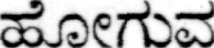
ಹೋಗುವ
